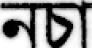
নচা
